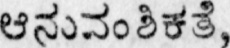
ಆನುವಂಶಿಕತೆ,
